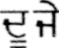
ਦੂਜੇ
